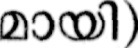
മായി)
